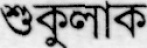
শুকুলাক
